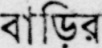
বাড়ির
